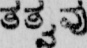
ತತ್ವವು
